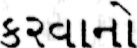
કરવાનો
